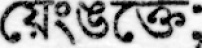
য়েংঙক্তে;
